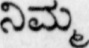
ನಿಮ್ಮ
